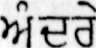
ਅੰਦਰੇ
